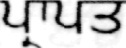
ਪ੍ਰਾਪਤ
